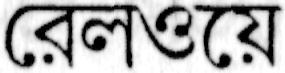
রেলওয়ে
